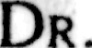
DR.
